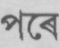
পৰে
